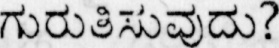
ಗುರುತಿಸುವುದು?
